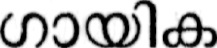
ഗായിക
